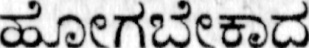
ಹೋಗಬೇಕಾದ
